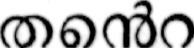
തന്റെ
